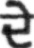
ਦੇ
